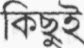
কিছুই
